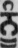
ਨੂੰ
